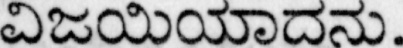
ವಿಜಯಿಯಾದನು.
